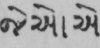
જેઓએ
